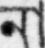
না
